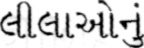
લીલાઓનું
